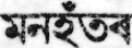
মনহঁতৰ
